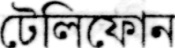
টেলিফোন
